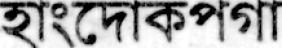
হাংদোকপগা
